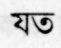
যত
